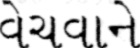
વેચવાને
